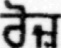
ਰੋਜ਼
